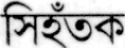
সিহঁতক
